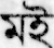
মই
